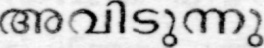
അവിടുന്നു
